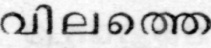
വിലത്തെ
